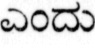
ಎಂದು
